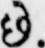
છે.
